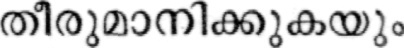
തീരുമാനിക്കുകയും
